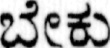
ಬೇಕು
